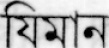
যিমান
